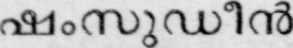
ഷംസുഡീന്‍
